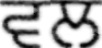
ਵਲ
